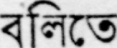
বলিতে
